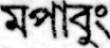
মপাবুং
